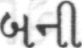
બની
